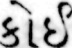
કોઈ
